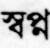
স্বপ্ন
